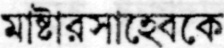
মাষ্টারসাহেবকে
